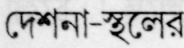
দেশনা-স্থলের
